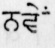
ਨਵੇਂ
